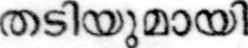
തടിയുമായി
